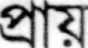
প্রায়
